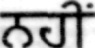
ਨਹੀਂ
